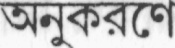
অনুকরণে
